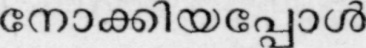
നോക്കിയപ്പോള്‍
